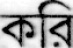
করি
